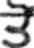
ਤੋਂ
